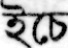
ইচে
